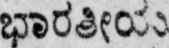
ಭಾರತೀಯ
